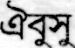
ঐবুসু
